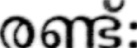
രണ്ട്:
